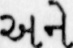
અને
